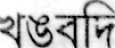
খঙবদি
